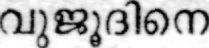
വുജൂദിനെ
